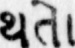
થતો
